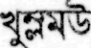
খু্ম্লকউ
